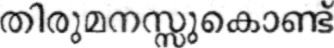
തിരുമനസ്സുകൊണ്ട്
